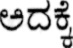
ಅದಕ್ಕೆ
